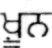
ਖ਼ੂਨ
